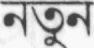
নতুন
